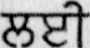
ਲਈ
